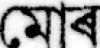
মোৰ
